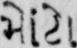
મોટો
